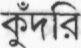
কুঁদরি
